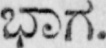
ಭಾಗ.
